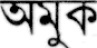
অমুক
